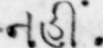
નહીં.
